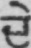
ਦੇ
